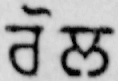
ਰੋਲ
